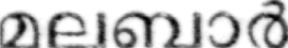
മലബാര്‍
